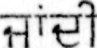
ਜਾਂਦੀ
